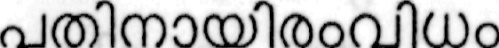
പതിനായിരംവിധം
